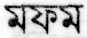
মফম
